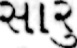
સારુ
